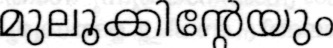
മുലൂക്കിൻ്റെയും
